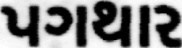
પગથાર
